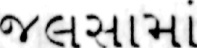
જલસામાં
